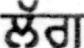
ਲੱਗ
